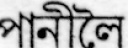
পানীলৈ
